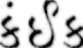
કંઈક
